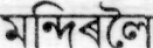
মন্দিৰলৈ
